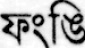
ফংঙি
